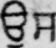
ਉਸ
